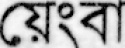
য়েংবা
